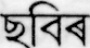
ছবিৰ
